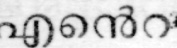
എന്റെ
